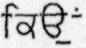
ਕਿਉਂ
